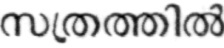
സത്രത്തില്‍
